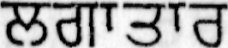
ਲਗਾਤਾਰ
